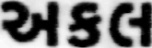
અકલ
